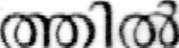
ത്തില്‍
